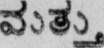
ಮತ್ತು
